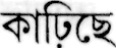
কাঢ়িছে
